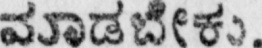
ಮಾಡಬೇಕು.
